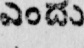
ಎಂದು
